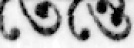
তেন্তে
